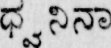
ಧ್ವನಿನಾ
